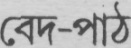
বেদ-পাঠ
